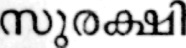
സുരക്ഷി
